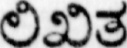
ಲಿಖಿತ
